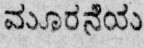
ಮೂರನೆಯ
